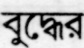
বুদ্ধের
